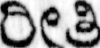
ರೀತಿ
